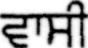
ਵਾਸੀ
